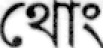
থোং
